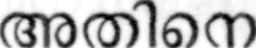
അതിനെ
